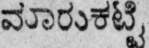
ಮಾರುಕಟ್ಟೆ
